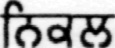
ਨਿਕਲ
